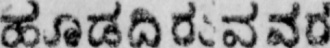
ಹೂಡದಿರುವವರ
